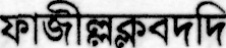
ফাজীল্লক্লবদদি
